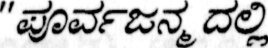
“ಪೂರ್ವಜನ್ಮದಲ್ಲಿ
